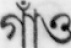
গাঁও
